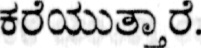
ಕರೆಯುತ್ತಾರೆ.
